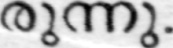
രുന്നു.
